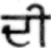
ਦੀ
